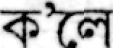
ক'লে
